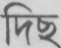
দিছ
